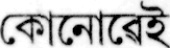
কোনোৱেই
